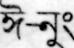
ঈ-নুং
